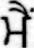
ਮੈਂ
